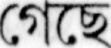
গেছে
